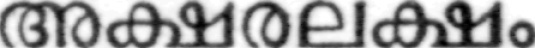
അക്ഷരലക്ഷം
